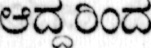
ಆದ್ದರಿಂದ
